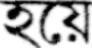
হয়ে
